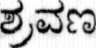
ಶ್ರವಣ
